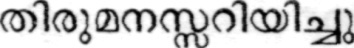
തിരുമനസ്സറിയിച്ചു
